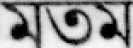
মতম
